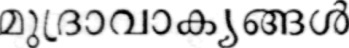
മുദ്രാവാക്യങ്ങള്‍
